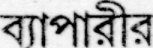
ব্যাপারীর
